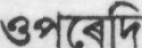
ওপৰেদি
